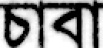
চাবা
